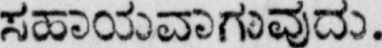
ಸಹಾಯವಾಗುವುದು.
